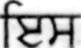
ਇਸ
